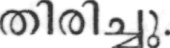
തിരിച്ചു.
